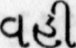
વહી
